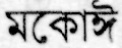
মকোঈ
